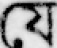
যে
